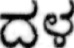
ದಳ
